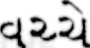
વચ્ચે
